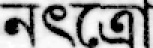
নৎত্রো
